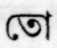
তো
